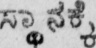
ಸ್ಥಾನಕ್ಕೆ
